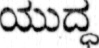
ಯುದ್ಧ
